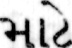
માટે
